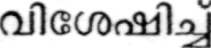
വിശേഷിച്ച്
